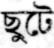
ছুটে
